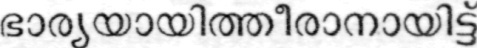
ഭാര്യയായിത്തീരാനായിട്ട്
